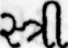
સ્ત્રી
